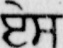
ਏਸ
